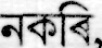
নকৰি,
